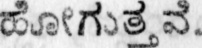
ಹೋಗುತ್ತವೆ.
